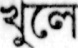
খুলে
